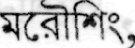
মরৌশিং,
